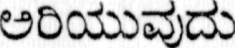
ಅರಿಯುವುದು
